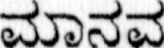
ಮಾನವ
